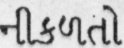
નીકળતો
